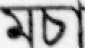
মচা
